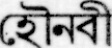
হৌনবী
